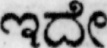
ಇದೇ
